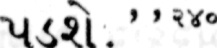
પડશે."૨૪૦
